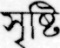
সৃষ্টি
